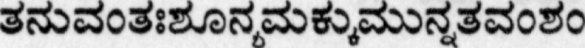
ತನುವಂತಃಶೂನ್ಯಮಕ್ಕುಮುನ್ನತವಂಶಂ
